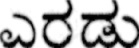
ಎರಡು
